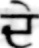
ਦੇ
